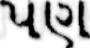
પણ
